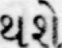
થશે
